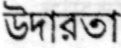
উদারতা
